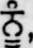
ਨੂੰ,
